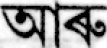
আৰু
